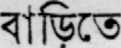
বাড়িতে
